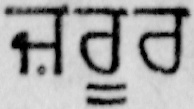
ਜ਼ਰੂਰ
